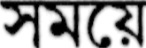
সময়ে
